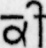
ਕੀ
